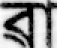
ৱা
